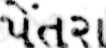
પેંતરા
